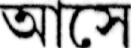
আসে
